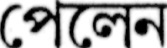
পেলেন
